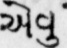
એવું
